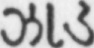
ઝાડ
